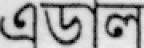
এডাল
